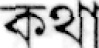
কথা
